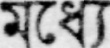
মধ্যে
